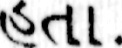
હતા.
